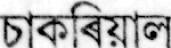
চাকৰিয়াল
